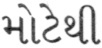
મોટેથી
